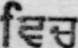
ਵਿਚ
